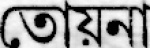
তোয়না
